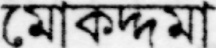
মোকদ্দমা
